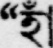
‘‘হাঁ
